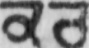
ਕਰ
